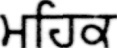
ਮਹਿਕ
